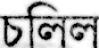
চলিল
